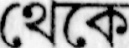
থেকে
